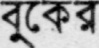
বুকের
